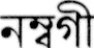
নম্বগী
